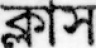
ক্লাস
